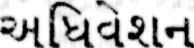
અધિવેશન
